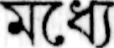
মধ্যে
